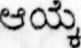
ಆಯ್ಕೆ
